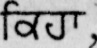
ਕਿਹਾ,
